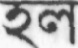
হল
